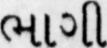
ભાગી
